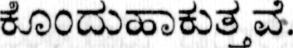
ಕೊಂದುಹಾಕುತ್ತವೆ.
